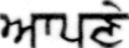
ਆਪਣੇ
